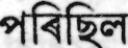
পৰিছিল
